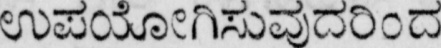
ಉಪಯೋಗಿಸುವುದರಿಂದ
